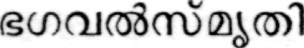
ഭഗവല്‍സ്മൃതി
